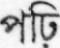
পঢ়ি
